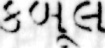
કબૂલ
